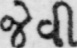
જેવી
